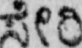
ಸೇರಿ
